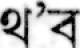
থ'ব
